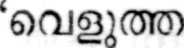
‘വെളുത്ത
